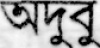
অদুবু
